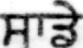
ਸਾਡੇ
